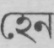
হেন
